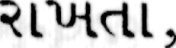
રાખતા,
